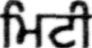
ਮਿਟੀ
